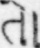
તો
